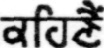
ਕਹਿਣੈਂ
